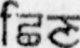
ਛਿਣ
